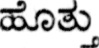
ಹೊತ್ತು
